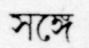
সঙ্গে
